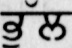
ਭੁੱਲ
